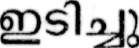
ഇടിച്ചു
